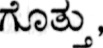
ಗೊತ್ತು,
